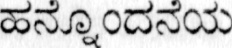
ಹನ್ನೊಂದನೆಯ
